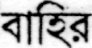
বাহির
